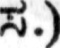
ಸ.)
